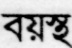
বয়স্থ
